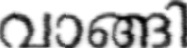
വാങ്ങി
